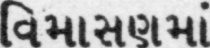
વિમાસણમાં
